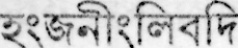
হংজনীংলিবদি
